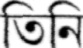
তিনি
